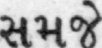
સમજે
